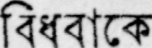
বিধবাকে
